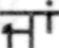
ਜਾਂ
